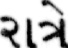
રાત્રે
